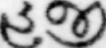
હજી
